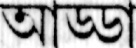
আড্ডা
